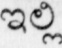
ಇಲ್ಲಿ
